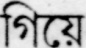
গিয়ে
